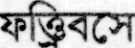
ফত্ত্রিবসে
